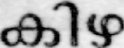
കിഴ
